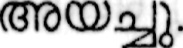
അയച്ചു.
